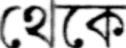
থেকে
